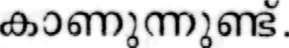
കാണുന്നുണ്ട്.
